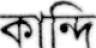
কান্দি
